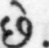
છે.
